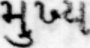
મુખ્ય
